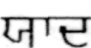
ਯਾਦ
